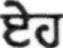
ਏਹ
